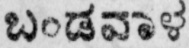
ಬಂಡವಾಳ
